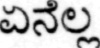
ಏನೆಲ್ಲ
